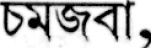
চমজবা,
